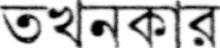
তখনকার
